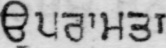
ਉਪਰਾਮਤਾ
